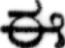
ಈ
